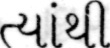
ત્યાંથી
